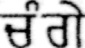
ਚੰਗੇ
